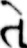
તે
